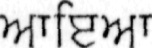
ਆਇਆ
